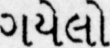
ગયેલો
